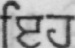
ਇਹ
